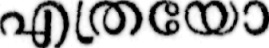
എത്രയോ
